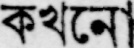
কখনো
